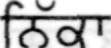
ਨਿੱਕਾ
